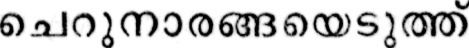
ചെറുനാരങ്ങയെടുത്ത്
